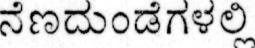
ನೆಣದುಂಡೆಗಳಲ್ಲಿ
